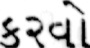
કરવો
